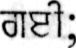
ਗਈ;
